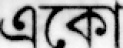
একো
